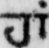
ਹਾਂ
